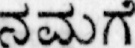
ನಮಗೆ
